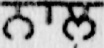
ਨਾਲ
